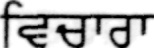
ਵਿਚਾਰਾ
